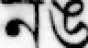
নঙ
